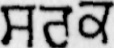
ਸਰਕ
